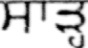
ਸਾੜ੍ਹ
